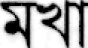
মখা
